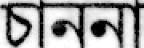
চাননা
